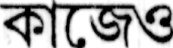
কাজেও
